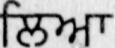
ਲਿਆ
